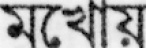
মখোয়
